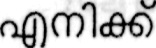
എനിക്ക്
